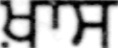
ਖ਼ਾਸ
